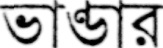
ভাণ্ডার
